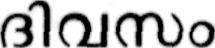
ദിവസം
